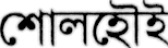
শোলহৌই
